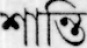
শান্তি
